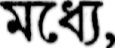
মধ্যে,
